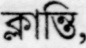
ক্লান্তি,
